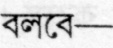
বলবে–
